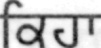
ਕਿਹਾ
